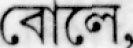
বোলে,
